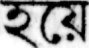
হয়ে
